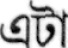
এটা
